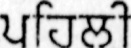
ਪਹਿਲੀ
